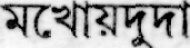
মখোয়দুদা
